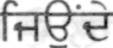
ਜਿਉਂਦੇ
